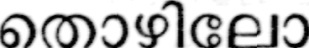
തൊഴിലോ
